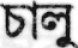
চালু
